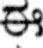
ಈ
